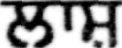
ਲਾਸ਼
